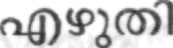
എഴുതി
